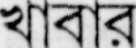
খাবার
